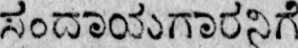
ಸಂದಾಯಗಾರನಿಗೆ
